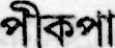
পীকপা
